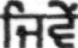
ਜਿਵੇਂ
